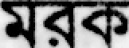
মরক
